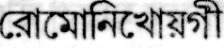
রোমোনিখোয়গী
